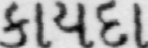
કાયદા
